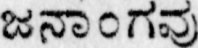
ಜನಾಂಗವು
